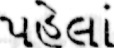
પહેલાં
